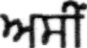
ਅਸੀਂ
